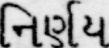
નિર્ણય
